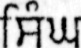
ਸਿੰਘ
